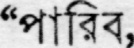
‘‘পারিব,
